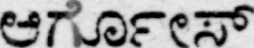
ಆರ್ಗೋಸ್
